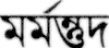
মর্মন্তুদ
